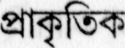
প্রাকৃতিক
